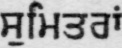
ਸੁਮਿਤਰਾਂ
